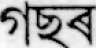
গছৰ
